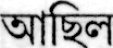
আছিল
